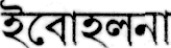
ইবোহলনা
